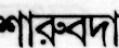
শারুবদা
